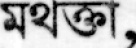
মথক্তা,
